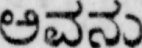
ಅವನು
